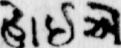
હોઈએ
